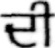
ਦੀ
